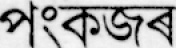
পংকজৰ
